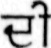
ਦੀ
